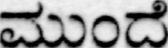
ಮುಂದೆ
